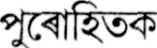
পুৰোহিতক
